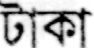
টাকা
